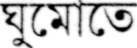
ঘুমোতে
